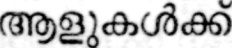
ആളുകള്‍ക്ക്
